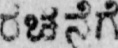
ರಚನೆಗೆ
